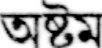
অষ্টম
